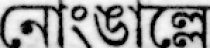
নোংঙাল্লে
